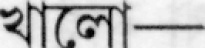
খালো-
